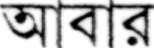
আবার
